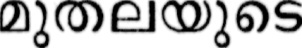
മുതലയുടെ
